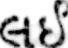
લઈ
